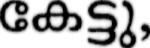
കേട്ടു,
